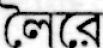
লৈরে
